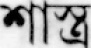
শাস্ত্র
